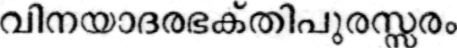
വിനയാദരഭക്തിപുരസ്സരം
